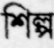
শিল্প
